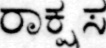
ರಾಕ್ಷಸ
